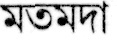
মতমদা
